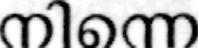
നിന്നെ
